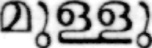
മുള്ളു
